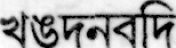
খঙদনবদি
